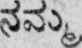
ನಮ್ಮ
